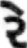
રે
